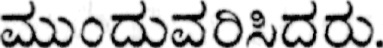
ಮುಂದುವರಿಸಿದರು.
